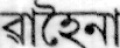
ৱাহৈনা
